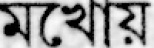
মখোয়
